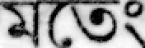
মতেং
